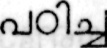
പഠിച്ച
